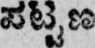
ಪಟ್ಟಣ
